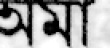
অমা
